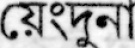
য়েংদুনা
